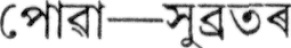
পোৱা-সুব্রতৰ
